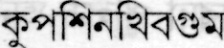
কুপশিনখিবগুম
